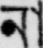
না
